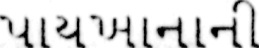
પાયખાનાની
